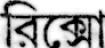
রিক্সো
